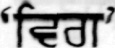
'ਵਿਗ'
